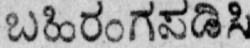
ಬಹಿರಂಗಪಡಿಸಿ
